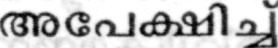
അപേക്ഷിച്ച്
